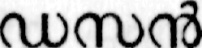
ഡസന്‍
